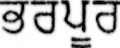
ਭਰਪੂਰ
